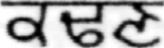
ਕਢਣ
